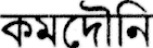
কমদৌনি
